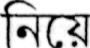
নিয়ে
